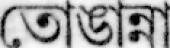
তোঙান্না
